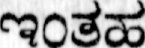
ಇಂತಹ
